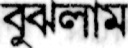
বুঝলাম
